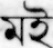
মই
